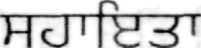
ਸਹਾਇਤਾ
